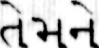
તેમને
